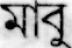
মাবু
